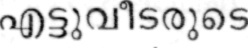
എട്ടുവീടരുടെ
